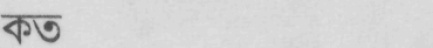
কত
